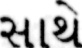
સાથે
